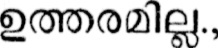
ഉത്തരമില്ല.,
